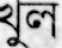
খুল
